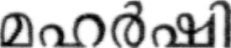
മഹര്‍ഷി
